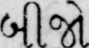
બીજો
